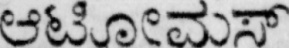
ಆಟೋಮಸ್
